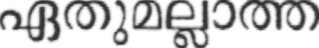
ഏതുമല്ലാത്ത
